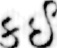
કઈ
